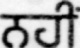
ਨਹੀਂ
